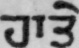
ਹਾਤੇ
